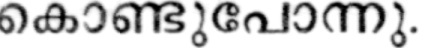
കൊണ്ടുപോന്നു.
